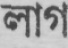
লাগ
